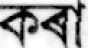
কৰা
